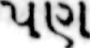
પણ
